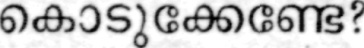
കൊടുക്കേണ്ടേ?
